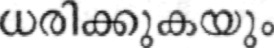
ധരിക്കുകയും
